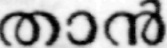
താന്‍
